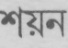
শয়ন
